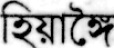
হিয়াঙ্গৈ
